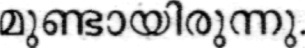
മുണ്ടായിരുന്നു.
